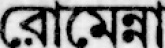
রোমেন্না
